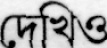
দেখিও
